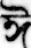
ঈ
